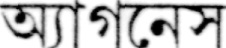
অ্যাগনেস
